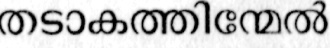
തടാകത്തിന്മേല്‍
